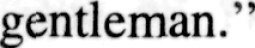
gentleman."
